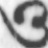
ও
